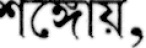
শঙ্গোই,
